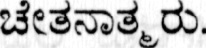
ಚೇತನಾತ್ಮರು.
